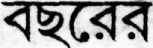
বছরের
